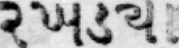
રખડ્યા
